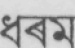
ধৰম
